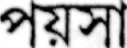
পয়সা
